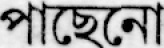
পাছেনো
